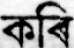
কৰি
